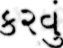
કરવું
